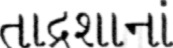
તાદ્રશાનાં
